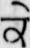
ਕੇ
